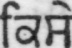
ਕਿਸੇ
